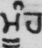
ਮੂੰਹ
